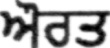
ਔਰਤ
